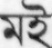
মই
